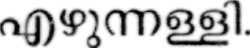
എഴുന്നള്ളി.
